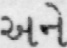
અને
